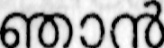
ഞാന്‍
